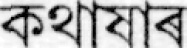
কথাষাৰ
